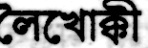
লৈখোক্কী
